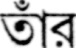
তাঁর
